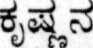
ಕೃಷ್ಣನ
